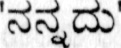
‘ನನ್ನದು’
